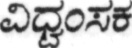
ವಿಧ್ವಂಸಕ
